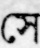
সে
